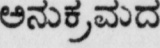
ಅನುಕ್ರಮದ
